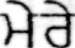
ਮੇਰੇ
